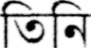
তিনি
